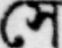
সে
